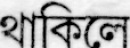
থাকিলে
